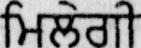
ਮਿਲੇਗੀ
